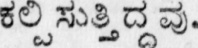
ಕಲ್ಪಿಸುತ್ತಿದ್ದವು.
